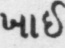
ખાઈ
